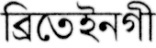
ব্রিতেইনগী
